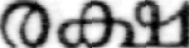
രക്ഷ
